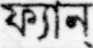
ফ্যান্
